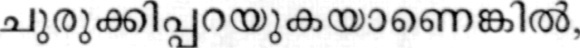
ചുരുക്കിപ്പറയുകയാണെങ്കില്‍,
